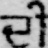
ਦੀ
